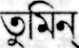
তুমিন্
